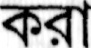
করা
